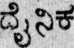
ದೈನಿಕ
